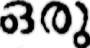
ഒരു
